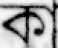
কা
